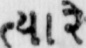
ત્યારે
